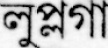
লুপ্লগা
